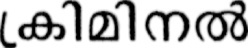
ക്രിമിനല്‍
